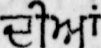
ਦੀਆਂ
